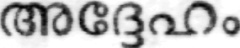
അദ്ദേഹം
